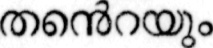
തന്റെയും
